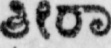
ತೀರಾ
